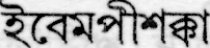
ইবেমপীশক্কা
